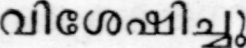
വിശേഷിച്ചു
